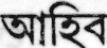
আহিব
